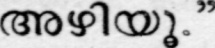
അഴിയൂ."
